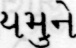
યમુને
